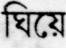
ঘিয়ে
